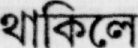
থাকিলে
